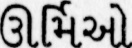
ઊર્મિઓ
